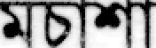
মচাশা
